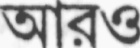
আরও
